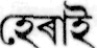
হেৰাই
